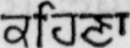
ਕਹਿਣਾ
